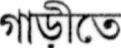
গাড়ীতে
